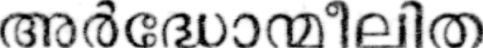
അര്‍ദ്ധോന്മീലിത
